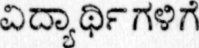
ವಿದ್ಯಾರ್ಥಿಗಳಿಗೆ
